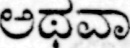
ಅಥವಾ
